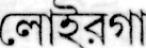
লোইরগা
